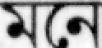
মনে
